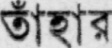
তাঁহার
